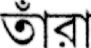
তাঁরা
